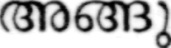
അങ്ങു
